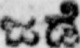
ಜಡೆ
